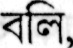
বলি,
